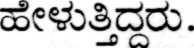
ಹೇಳುತ್ತಿದ್ದರು.
